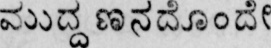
ಮುದ್ದಣನದೊಂದೇ
